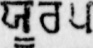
ਯੂਰਪ
